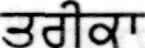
ਤਰੀਕਾ
